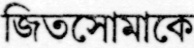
জিতসোমাকে
